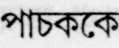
পাচককে
